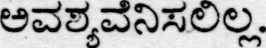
ಅವಶ್ಯವೆನಿಸಲಿಲ್ಲ.
